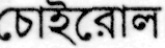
চোইরোল
